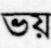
ভয়
